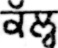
ਕੱਲ੍ਹ
